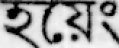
হয়েং
